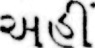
અહીં
